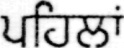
ਪਹਿਲਾਂ
